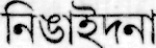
নিঙাইদনা
